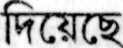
দিয়েছে
